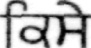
ਕਿਸੇ
